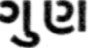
ગુણ
